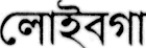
লোইবগা
